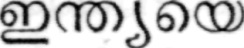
ഇന്ത്യയെ
